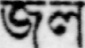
জল
